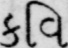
કવિ
